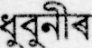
ধুবুনীৰ
